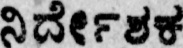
ನಿರ್ದೇಶಕ
